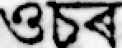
ওচৰ
